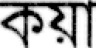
কয়া
